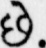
છે.
